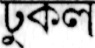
ঢুকল
